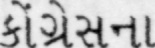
કોંગ્રેસના
